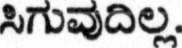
ಸಿಗುವುದಿಲ್ಲ.
